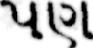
પણ
